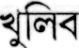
খুলিব
